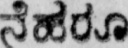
ನೆಹರೂ
